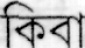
কিবা
